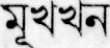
মূখখন
